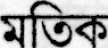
মতিক
